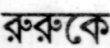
রুরুকে
